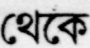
থেকে
